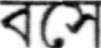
বসে
